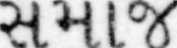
સમાજ
